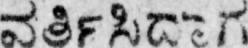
ವರ್ತಿಸಿದಾಗ
